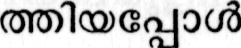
ത്തിയപ്പോള്‍
